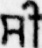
ਸੀ
